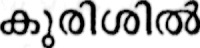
കുരിശില്‍
